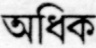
অধিক
